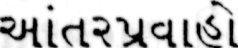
આંતરપ્રવાહો
